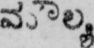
ಮೌಲ್ಯ
